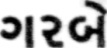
ગરબે
